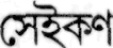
সেইকণ
